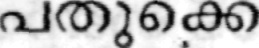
പതുക്കെ
